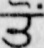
ਤੋਂ
